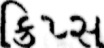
ક્રિપ્સ
